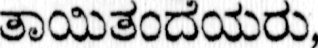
ತಾಯಿತಂದೆಯರು,
